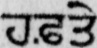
ਹਫ਼ਤੇ
